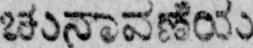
ಚುನಾವಣೆಯ
